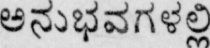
ಅನುಭವಗಳಲ್ಲಿ
